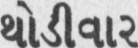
થોડીવાર
